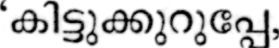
‘കിട്ടുക്കുറുപ്പേ,
